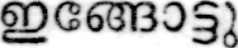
ഇങ്ങോട്ടു
